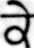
ਕੇ
